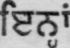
ਇਨ੍ਹਾਂ
